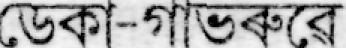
ডেকা-গাভৰুৱে
